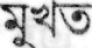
মুখত
